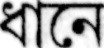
ধানে
